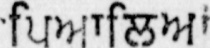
ਪਿਆਲਿਆਂ
